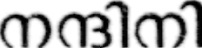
നന്ദിനി
